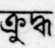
ক্রুদ্ধ
